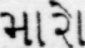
મારો
